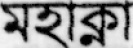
মহাক্না
